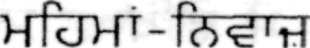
ਮਹਿਮਾਂ-ਨਿਵਾਜ਼
